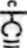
ਨੂੰ
